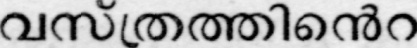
വസ്ത്രത്തിന്റെ
